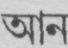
আন
